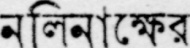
নলিনাক্ষের
